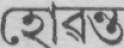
হোৱন্ত
